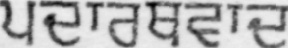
ਪਦਾਰਥਵਾਦ
